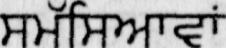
ਸਮੱਸਿਆਵਾਂ
